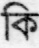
কি
